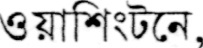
ওয়াশিংটনে,
